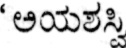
'ಅಯಶಸ್ವಿ
